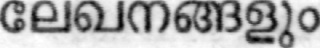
ലേഖനങ്ങളും
